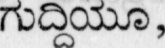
ಗುದ್ದಿಯೂ,
